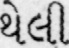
થેલી
